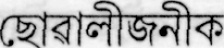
ছোৱালীজনীক
